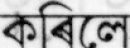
কৰিলে
